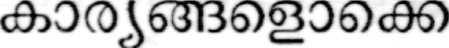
കാര്യങ്ങളൊക്കെ
